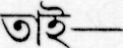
তাই-
